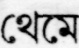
থেমে
